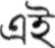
এই
